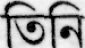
তিনি
